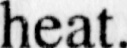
heat.
